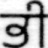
ਭੀ
